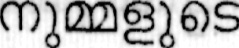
നുമ്മളുടെ
